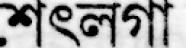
শেৎলগা
